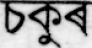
চকুৰ
